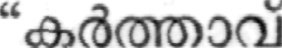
“കര്‍ത്താവ്
